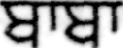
ਬਾਬਾ
